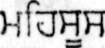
ਮਹਿਸੂਸ
